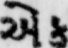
એક
